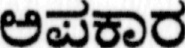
ಅಪಕಾರ
